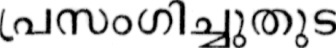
പ്രസംഗിച്ചുതുട
